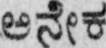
ಅನೇಕ
